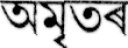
অমৃতৰ
